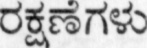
ರಕ್ಷಣೆಗಳು
